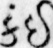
કંઈ
